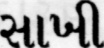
સાખી
